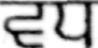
ਵਧ
